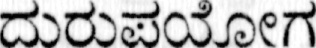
ದುರುಪಯೋಗ
